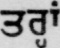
ਤਰ੍ਹਾਂ
